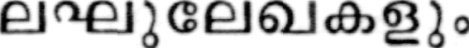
ലഘുലേഖകളും
